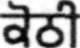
ਕੋਠੀ
